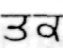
ਤਕ
